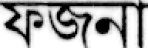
ফজনা
